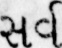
સર્વ
